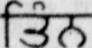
ਤਿੰਨ
